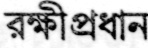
রক্ষীপ্রধান
